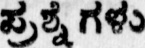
ಪ್ರಶ್ನೆಗಳು
